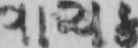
વાચક
